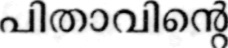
പിതാവിന്റെ
